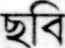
ছবি
